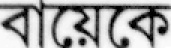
বায়েকে
